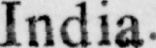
India.
